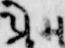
પ્રેમ
